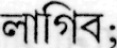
লাগিব;
